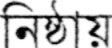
নিষ্ঠায়
